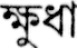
ক্ষুধা
